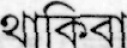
থাকিবা
